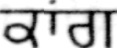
ਕਾਂਗ
